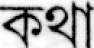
কথা
